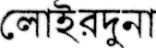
লোইরদুনা
